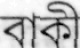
বাকী
